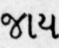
જાય
